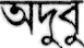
অদুবু
